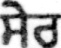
ਸੇਰ
